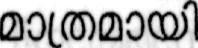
മാത്രമായി
